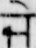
ਜੇ
